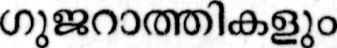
ഗുജറാത്തികളും
